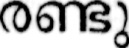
രണ്ടു
